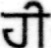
ਹੀ
